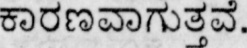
ಕಾರಣವಾಗುತ್ತವೆ.
